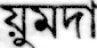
য়ুমদা
